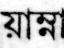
য়াম্না
